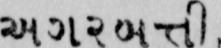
અગરબત્તી
